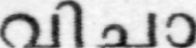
വിചാ
